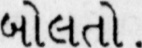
બોલતો.
